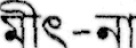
মীৎ-না
